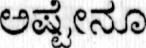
ಅಷ್ಟೇನೂ
